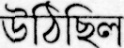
উঠিছিল
